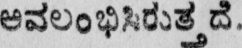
ಅವಲಂಭಿಸಿರುತ್ತದೆ.
